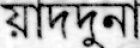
য়াদদুনা
